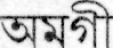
অমগী
